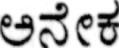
ಅನೇಕ
